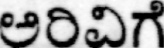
ಅರಿವಿಗೆ
